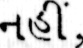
નહીં,
